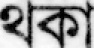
থকা
